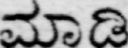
ಮಾಡಿ
